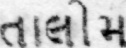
તાલીમ
